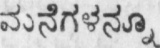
ಮನೆಗಳನ್ನೂ
